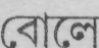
বোলে
